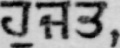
ਹੁਜਤ,
